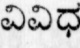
ವಿವಿಧ
